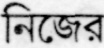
নিজের
